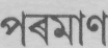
পৰমাণ
